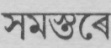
সমস্তৰে
